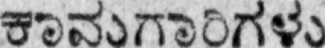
ಕಾಮಗಾರಿಗಳು
